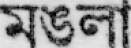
মঙলা
